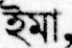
ইমা,
